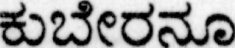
ಕುಬೇರನೂ
